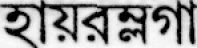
হায়রম্লগা
